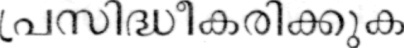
പ്രസിദ്ധീകരിക്കുക
